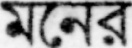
মনের
